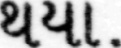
થયા.
